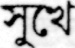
সুখে
